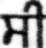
ਸੀ
